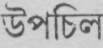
উপচিল
